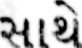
સાથે
